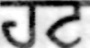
ਹਟ
